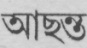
আছন্ত
